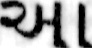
આ
